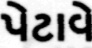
પેટાવે
